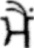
ਮੈਂ
